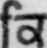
ਕਿ
